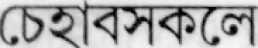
চেহাবসকলে
